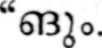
“ങും.
